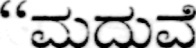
"ಮದುವೆ
